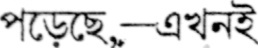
পড়়েছে,—এখনই
